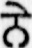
ਨੇ
